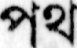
পথ
